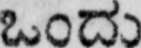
ಒಂದು
